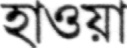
হাওয়া
